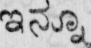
ಇನ್ನೂ
